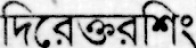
দিরেক্তরশিং
